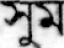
সুম
